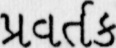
પ્રવર્તક
